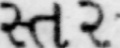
સ્તર
